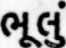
ભૂલું
